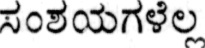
ಸಂಶಯಗಳೆಲ್ಲ
